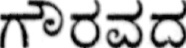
ಗೌರವದ
